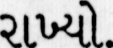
રાખ્યો.
